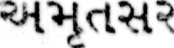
અમૃતસર
